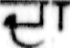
ਦਾ
